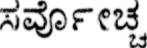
ಸರ್ವೋಚ್ಚ
